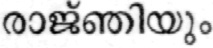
രാജ്ഞിയും
